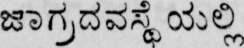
ಜಾಗ್ರದವಸ್ಥೆಯಲ್ಲಿ
